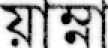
য়াম্না
